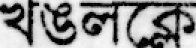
খঙলক্লে
